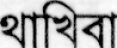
থাখিবা
